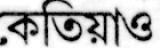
কেতিয়াও
